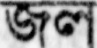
জল
